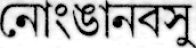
নোংঙানবসু
